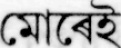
মোৰেই
